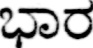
ಭಾರ
